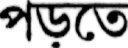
পড়তে
